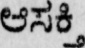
ಆಸಕ್ತಿ
